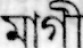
মাগী
